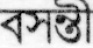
বসন্তী
